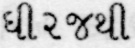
ધીરજથી
